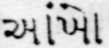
આંખો
